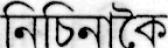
নিচিনাকৈ
